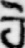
ਹੋ
